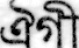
ঐগী
